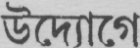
উদ্যোগে
